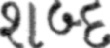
શબ્દ
